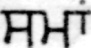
ਸਮਾਂ
